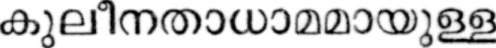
കുലീനതാധാമമായുള്ള
